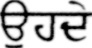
ਉਹਦੇ
